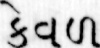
કેવળ
